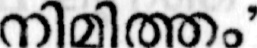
നിമിത്തം’
